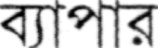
ব্যাপার
